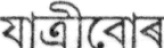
যাত্রীবোৰ
